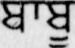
ਬਾਬੂ
